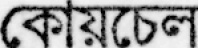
কোয়চেল
